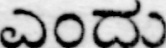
ಎಂದು
